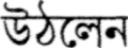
উঠলেন
